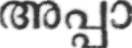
അപ്പാ
